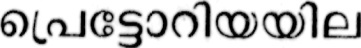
പ്രെട്ടോറിയയില
